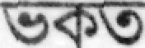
ভকত
